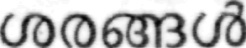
ശരങ്ങള്‍
